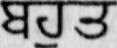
ਬਹੁਤ
